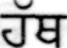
ਹੱਥ
